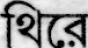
থিরে
